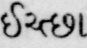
ઈચ્ત્છા
